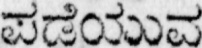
ಪಡೆಯುವ
